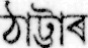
ঠাট্টাৰ
